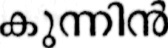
കുന്നിന്‍
